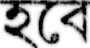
হবে
